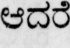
ಆದರೆ
